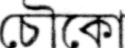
চৌকো
